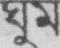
ঘুম
